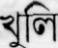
খুলি
